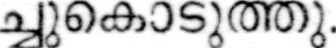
ച്ചുകൊടുത്തു.
